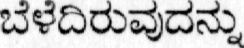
ಬೆಳೆದಿರುವುದನ್ನು
